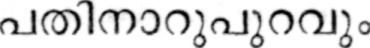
പതിനാറുപുറവും
